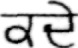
ਕਦੇ
